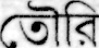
তৌরি
